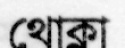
থোক্না
